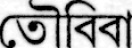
তৌবিবা
